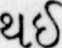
થઈ
